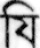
যি
